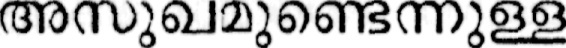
അസുഖമുണ്ടെന്നുള്ള
